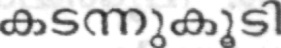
കടന്നുകൂടി
